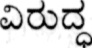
ವಿರುದ್ಧ
